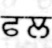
ਫਲ
